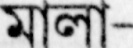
মালা-
